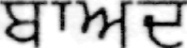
ਬਾਅਦ
